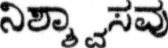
ನಿಶ್ಶ್ವಾಸವು
